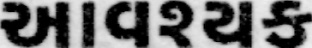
આવશ્યક
